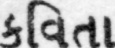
કવિતા
